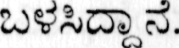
ಬಳಸಿದ್ದಾನೆ.
